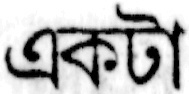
একটা
